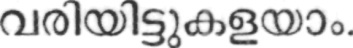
വരിയിട്ടുകളയാം.
